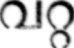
വറ്റ
